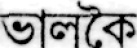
ভালকৈ
